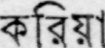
করিয়া
